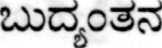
ಬುದ್ಯಂತನ
